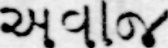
અવાજ
